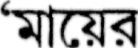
'মায়ের
